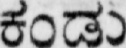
ಕಂಡು
